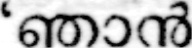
‘ഞാന്‍
